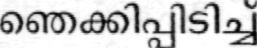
ഞെക്കിപ്പിടിച്ച്
